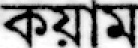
কয়াম
